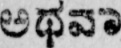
ಅಥವಾ
